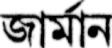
জার্মান
